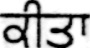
ਕੀਤਾ
